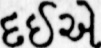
દઈએ
